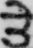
ਤੇ
